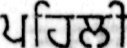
ਪਹਿਲੀ
